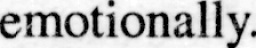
emotionally.
